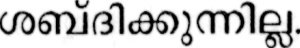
ശബ്ദിക്കുന്നില്ല.
